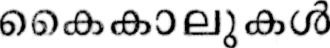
കൈകാലുകള്‍
